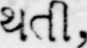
થતી,
